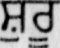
ਸ਼ੁਰੂ
